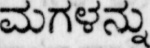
ಮಗಳನ್ನು
